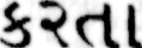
કરતા
